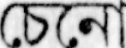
চেনো
